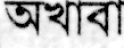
অখাবা
